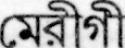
মেরীগী
